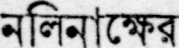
নলিনাক্ষের
